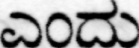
ಎಂದು
